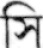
সি
